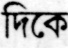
দিকে
